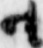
ન
